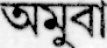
অমুবা
